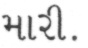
મારી.
